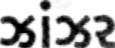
ઝાંઝર
